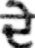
ਦੇ
